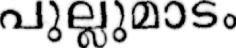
പുല്ലുമാടം
